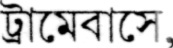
ট্রামেবাসে,
